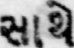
સાથે
